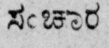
ಸಂಚಾರ
